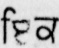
ਇਕ
